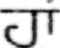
ਹਾਂ
